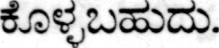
ಕೊಳ್ಳಬಹುದು.
